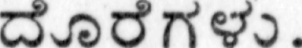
ದೊರೆಗಳು.
